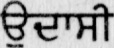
ਉਦਾਸੀ
